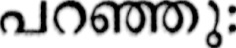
പറഞ്ഞു:
